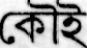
কৌই
